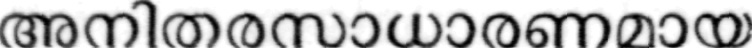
അനിതരസാധാരണമായ
